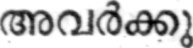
അവര്‍ക്കു
